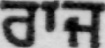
ਰਾਜ
